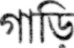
গাড়ি
